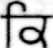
ਕਿ
